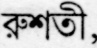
রুশতী,
